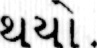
થયો.
